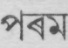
পৰম
